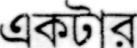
একটার
